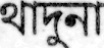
থাদুনা
